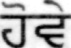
ਹੋਵੇ
